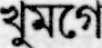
খুমগে
